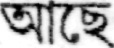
আছে
